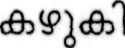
കഴുകി
